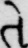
તે
